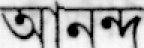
আনন্দ
